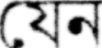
যেন
